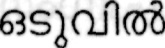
ഒടുവില്‍
